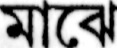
মাঝে
